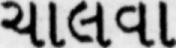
ચાલવા
